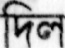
দিল
